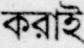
করাই
